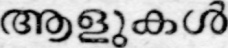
ആളുകള്‍
